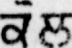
ਕੋਲ
